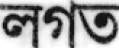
লগত
